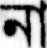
না
